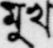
মুখ
